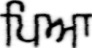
ਪਿਆ
